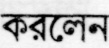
করলেন
